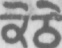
ਕੋਠੇ
